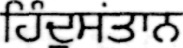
ਹਿੰਦੁਸਤਾਨ
